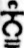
ਨੂੰ
